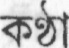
কণ্ঠা
